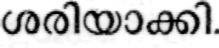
ശരിയാക്കി.
